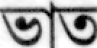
ভাত
